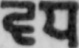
ਵਧ
